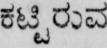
ಕಟ್ಟಿರುವ
